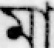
মা
